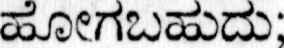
ಹೋಗಬಹುದು;
